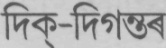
দিক্-দিগন্তৰ
